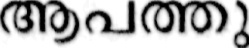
ആപത്തു
